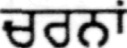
ਚਰਨਾਂ
